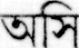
অসি
